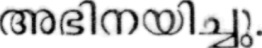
അഭിനയിച്ചു.
